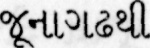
જૂનાગઢથી
